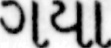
ગયા
